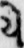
યે
